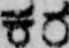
ಕರ
